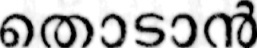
തൊടാന്‍
